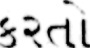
કરતો
